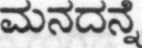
ಮನದನ್ನೆ
